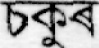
চকুৰ
